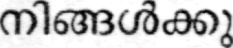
നിങ്ങള്‍ക്കു
